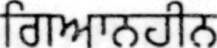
ਗਿਆਨਹੀਨ
